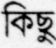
কিছু
